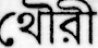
থৌরী
